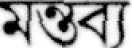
মন্তব্য
